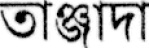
তাঞ্জাদা
